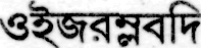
ওইজরম্লবদি
